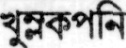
খুম্লকপনি
